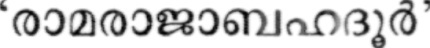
'രാമരാജാബഹദൂര്‍'
